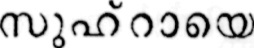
സുഹ്റായെ
